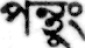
পন্থুং
